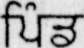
ਪਿੰਡ
